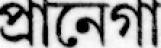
প্রানেগা
